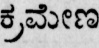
ಕ್ರಮೇಣ
